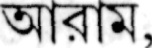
আরাম,
